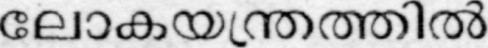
ലോകയന്ത്രത്തില്‍
